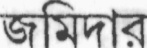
জমিদার
